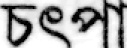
চৎপা
